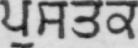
ਪੁਸਤਕ
